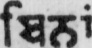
ਬਿਨਾਂ
